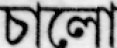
চালো
